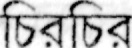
চিরচির
